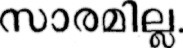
സാരമില്ല.
